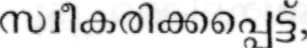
സ്വീകരിക്കപ്പെട്ട്,
